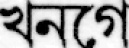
খনগে
